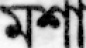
মশা
